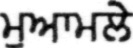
ਮੁਆਮਲੇ
